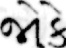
જોકે
